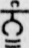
ਨੂੰ
